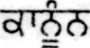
ਕਾਨੂੰਨ
